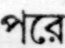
পরে
